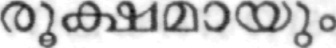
രൂക്ഷമായും
